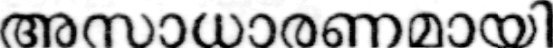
അസാധാരണമായി
